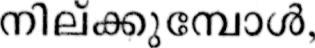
നില്ക്കുമ്പോള്‍,
